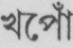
খপোঁ
